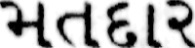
મતદાર
